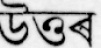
উত্তৰ
